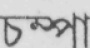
চম্পা
